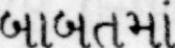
બાબતમાં
